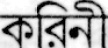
করিনী
